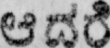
ಆದರೆ
